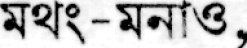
মথং-মনাও,
